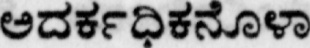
ಅದರ್ಕಧಿಕನೊಳಾ
